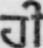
ਹੀ
